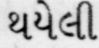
થયેલી
